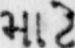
માટે
